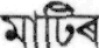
মাটিৰ
